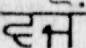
ਵਜੋਂ
